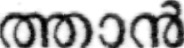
ത്താന്‍
